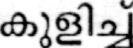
കുളിച്ച്
